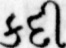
કદી
